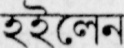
হইলেন
